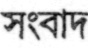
সংবাদ
